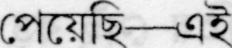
পেয়েছি–এই
